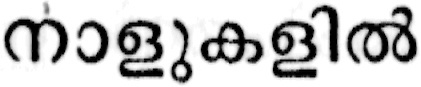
നാളുകളില്‍
